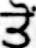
ਤੋਂ
